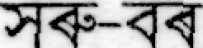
সৰু-বৰ
